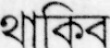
থাকিব
